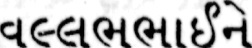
વલ્લભભાઈને
